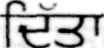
ਦਿੱਤਾ
